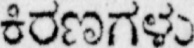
ಕಿರಣಗಳು
